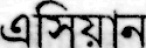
এসিয়ান
